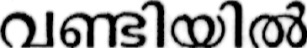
വണ്ടിയില്‍
